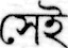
সেই
